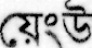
য়েংউ
